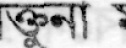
মতুংদা
